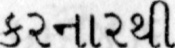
કરનારથી
